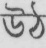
উঠ
